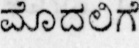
ಮೊದಲಿಗೆ
